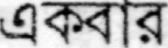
একবার
